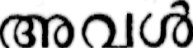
അവള്‍
